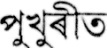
পুখুৰীত
